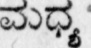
ಮಧ್ಯ
